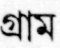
গ্রাম
